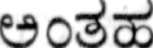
ಅಂತಹ
